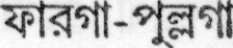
ফারগা-পূল্লগা
